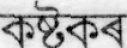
কষ্টকৰ
